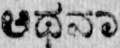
ಅಥವಾ
